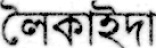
লৈকাইদা
